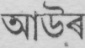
আউৰ
